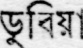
ডুবিয়া
